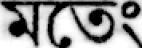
মতেং
